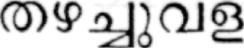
തഴച്ചുവള
